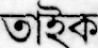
তাইক
